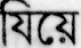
যিয়ে
